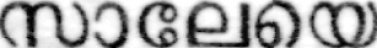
സാലേയെ
